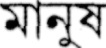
মানুষ
